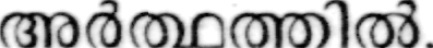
അര്‍ത്ഥത്തില്‍.
